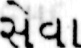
સેવા
